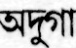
অদুগা
